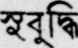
সুবুদ্ধি
